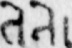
તેનો
